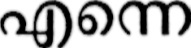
എന്നെ
